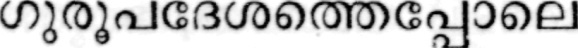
ഗുരൂപദേശത്തെപ്പോലെ
